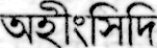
অহীংসিদি
